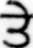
ਤੇ
